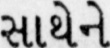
સાથેને
